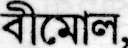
বীমোল,
